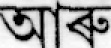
আৰু
